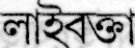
লাইবক্তা
